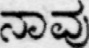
ನಾವು
